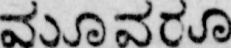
ಮೂವರೂ
